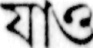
যাও
